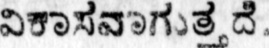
ವಿಕಾಸವಾಗುತ್ತದೆ.
